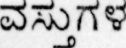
ವಸ್ತುಗಳ
